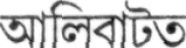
আলিবাটত
